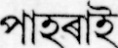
পাহৰাই
